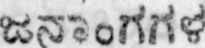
ಜನಾಂಗಗಳ
